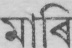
মাৰি
